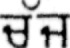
ਚੱਜ
